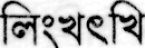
লিংখৎখি
